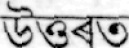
উত্তৰত
